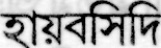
হায়বসিদি
